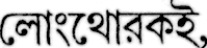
লোংথোরকই,
